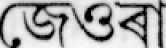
জেওৰা
